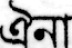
ঐনা
